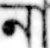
না
